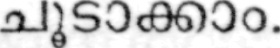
ചൂടാക്കം.
